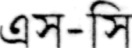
এস-সি
